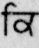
ਕਿ
